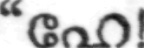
“ഹേ!
